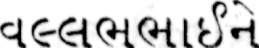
વલ્લભભાઈને
